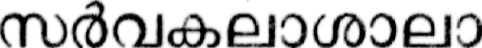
സര്‍വകലാശാലാ
